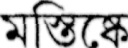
মস্তিষ্কে
